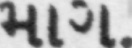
માગ.
